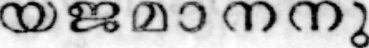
യജമാനനു
